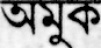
অমুক
